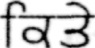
ਕਿਤੇ
